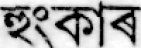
হুংকাৰ
